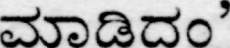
ಮಾಡಿದಂ’
